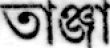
তাঞ্জা
